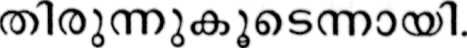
തിരുന്നുകൂടെന്നായി.
